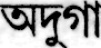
অদুগা
